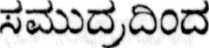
ಸಮುದ್ರದಿಂದ
